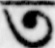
ত
